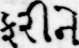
ફરીને
